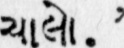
ચાલો.'
